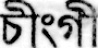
চীংগী
